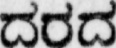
ದರದ
